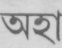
অহা
